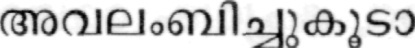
അവലംബിച്ചുകൂടാ
